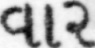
વાર
